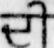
ਦੀ
